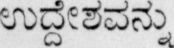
ಉದ್ದೇಶವನ್ನು
